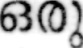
ഒരു
